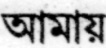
আমায়
